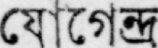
যোগেন্দ্র
